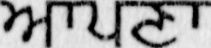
ਆਪਣਾ
